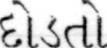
દોડતો
